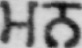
ਮਨ
